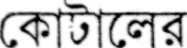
কোটালের
